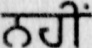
ਨਹੀਂ
